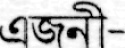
এজনী-
